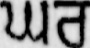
ਘਰ
